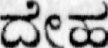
ದೇಹ
